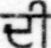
ਦੀ
